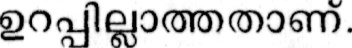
ഉറപ്പില്ലാത്തതാണ്.
